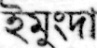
ইমুংদা
